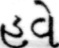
હવે
